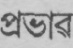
প্ৰভাৱ
